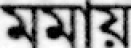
মমায়
